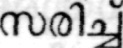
സരിച്ച്
